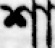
শা
